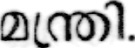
മന്ത്രി.
